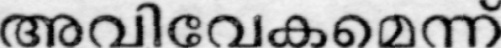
അവിവേകമെന്ന്
